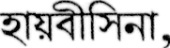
হায়বীসিনা,
